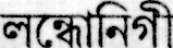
লন্ধোনিগী
